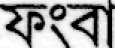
ফংবা
